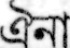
ঐনা
